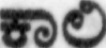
ಕಾಲಿ
